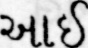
આઈ
